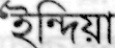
‘ইন্দিয়া
